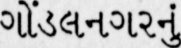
ગોંડલનગરનું
